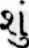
શું
